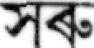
সৰু
